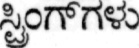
ಸ್ಟ್ರಿಂಗ್‌ಗಳು
